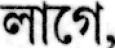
লাগে,
